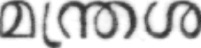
മന്ത്രശ
